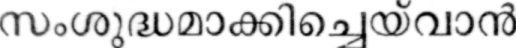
സംശുദ്ധമാക്കിച്ചെയ്‌വാന്‍
